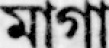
মাগা
